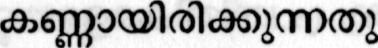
കണ്ണായിരിക്കുന്നതു
